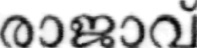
രാജാവ്
